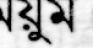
ময়ুম
